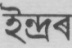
ইন্দ্ৰৰ
